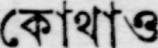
কোথাও
